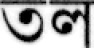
তল
